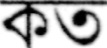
কত
